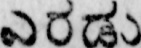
ಎರಡು
